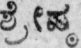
ಶ್ರೇಷ್ಠ
